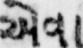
એવા
